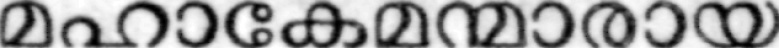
മഹാകേമന്മാരായ
